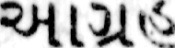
આગ્રહ
